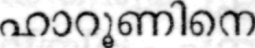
ഹാറൂണിനെ
